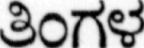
ತಿಂಗಳ
